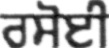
ਰਸੋਈ
